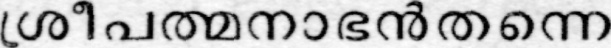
ശ്രീപത്മനാഭന്‍തന്നെ
